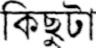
কিছুটা
